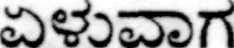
ಏಳುವಾಗ
